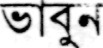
ভাবুন
